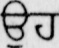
ਉਹ
